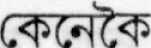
কেনেকৈ
